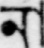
না
